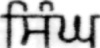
ਸਿੰਘ
